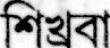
শিখ্রবা
